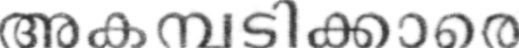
അകമ്പടിക്കാരെ
